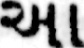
આ
